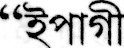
“ইপাগী
